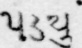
પડ્યું
